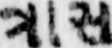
ત્રાસ
